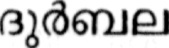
ദുര്‍ബല
